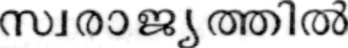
സ്വരാജ്യത്തില്‍
